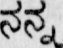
ನನ್ನ
